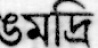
ঙমদ্রি
